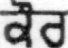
ਕੌਰ
